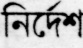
নির্দেশ
